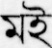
মই
